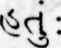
હતું:
